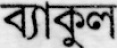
ব্যাকুল
